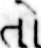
તો
